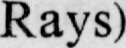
Rays)
